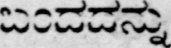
ಬಂದದನ್ನು
